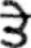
ਤੇ
